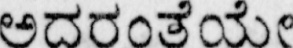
ಅದರಂತೆಯೇ
